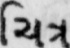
ચિત્ર
